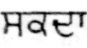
ਸਕਦਾ
